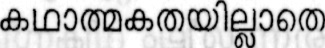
കഥാത്മകതയില്ലാതെ
